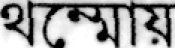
থম্মোয়
